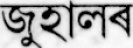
জুহালৰ
